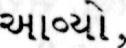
આવ્યો,
